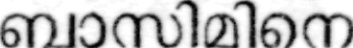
ബാസിമിനെ
